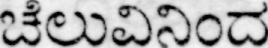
ಚೆಲುವಿನಿಂದ
